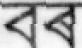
বৰ
